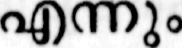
എന്നും
